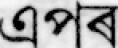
এপৰ
